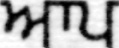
ਆਪ
